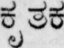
ಕೃತಕ
